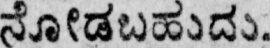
ನೋಡಬಹುದು.
